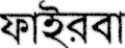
ফাইরবা
